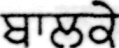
ਬਾਲਕੇ
